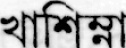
খাশিম্না
